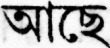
আছে
